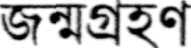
জন্মগ্রহণ
